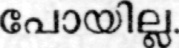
പോയില്ല.
